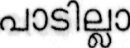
പാടില്ലാ
